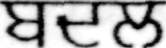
ਬਦਲ
